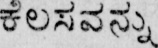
ಕೆಲಸವನ್ನು
